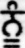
ਨੂੰ
